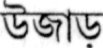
উজাড়
